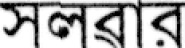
সলৱার
